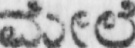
ಮೇಲೆ
